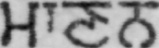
ਮਾਣਨ
